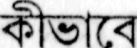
কীভাবে
